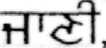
ਜਾਣੀ,
